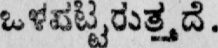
ಒಳಪಟ್ಟಿರುತ್ತದೆ.
